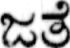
ಜತೆ
